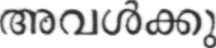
അവള്‍ക്കു
